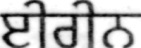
ਈਰੀਨ
